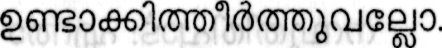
ഉണ്ടാക്കിത്തീര്‍ത്തുവല്ലോ.
